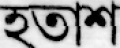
হতাশ
